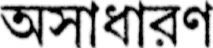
অসাধারণ
